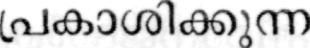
പ്രകാശിക്കുന്ന
